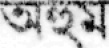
অহুম
